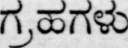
ಗ್ರಹಗಳು
